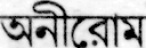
অনীরোম
